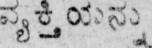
ವ್ಯಕ್ತಿಯನ್ನು
